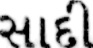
સાદી
